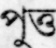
পুত্ত
